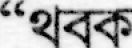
“থবক
